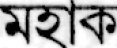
মহাক
